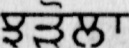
ਝੜੋਲਾ
